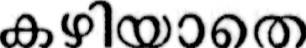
കഴിയാതെ
